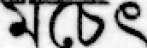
মচেৎ
